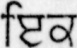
ਇਕ
